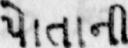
પોતાની
